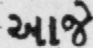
આજે
